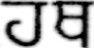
ਹਥ
